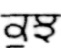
ਕੁਝ
